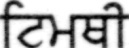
ਟਿਮਥੀ
